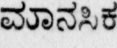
ಮಾನಸಿಕ
